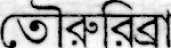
তৌরুরিব্রা
